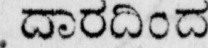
ದಾರದಿಂದ
